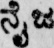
ನೈಜ
